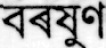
বৰষুণ
